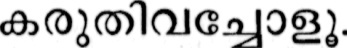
കരുതിവച്ചോളൂ.
